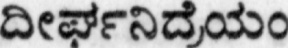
ದೀರ್ಘನಿದ್ರೆಯಂ
